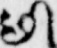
છી
